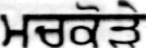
ਮਚਕੋੜੇ
